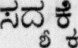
ಸದ್ಯಕ್ಕೆ
